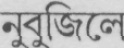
নুবুজিলে
